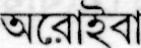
অরোইবা
